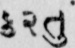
કરતું
